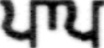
ਪਾਪ
